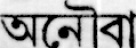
অনৌবা
